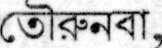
তৌরুনবা,
